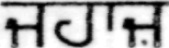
ਜ਼ਹਾਜ
